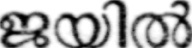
ജയില്‍
